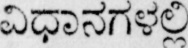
ವಿಧಾನಗಳಲ್ಲಿ
